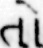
તો
